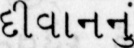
દીવાનનું
